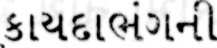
કાયદાભંગની
